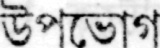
উপভোগ
